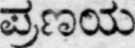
ಪ್ರಣಯ
